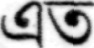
এত
